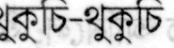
খুকুচি-থুকুচি
